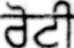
ਰੋਟੀ
